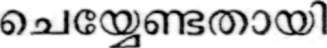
ചെയ്യേണ്ടതായി
